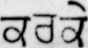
ਕਰਕੇ
